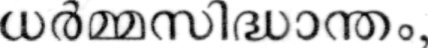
ധര്‍മ്മസിദ്ധാന്തം,
